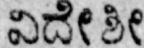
ವಿದೇಶೀ
